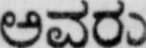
ಅವರು
